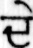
ਦੇ
